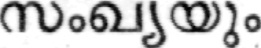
സംഖ്യയും
